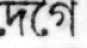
দেগৈ
